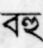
বহু
